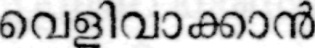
വെളിവാക്കാന്‍
